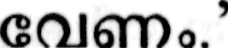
വേണം.’
